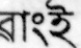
ৱাংই
